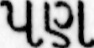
પણ
